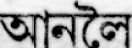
আনলৈ
